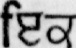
ਇਕ
